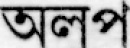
অলপ
